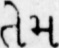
તેમ
